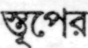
স্তূপের
